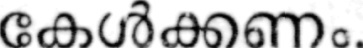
കേള്‍ക്കണം.
